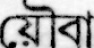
য়ৌবা
